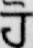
ਹੋ
